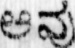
ಅವು
